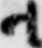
ન
